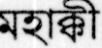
মহাক্কী
